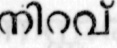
നിറവ്
